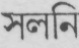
সলনি
